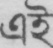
এই
